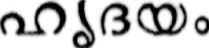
ഹൃദയം
